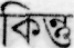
কিন্তু
